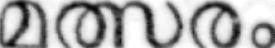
മത്സരം
